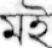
মই
